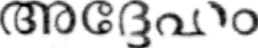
അദ്ദേഹം
